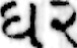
ઘર
